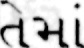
તેમાં
